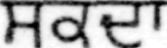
ਸਕਦਾ
